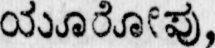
ಯೂರೋಪು,
